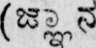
(ಜ್ಞಾನ
